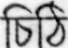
চিঠি
